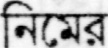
নিমের
